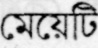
মেয়েটি
